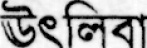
ঊৎলিবা
